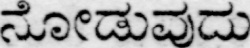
ನೋಡುವುದು
